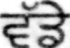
ਵੱਡੇ
